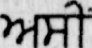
ਅਸੀਂ
